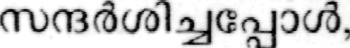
സന്ദര്‍ശിച്ചപ്പോള്‍,
